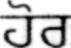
ਹੋਰ
